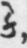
કે,
